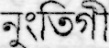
নুংতিগী
